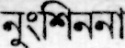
নুংশিননা
